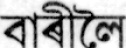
বাৰীলৈ
